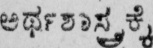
ಅರ್ಥಶಾಸ್ತ್ರಕ್ಕೆ
